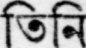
তিনি
